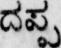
ದಪ್ಪ
